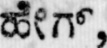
ಹೇಗ್,
